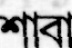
শাবা
